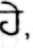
ਹੇ,
